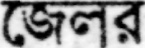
জেলর
